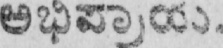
ಅಭಿಪ್ರಾಯ.
